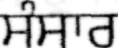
ਸੰਸਾਰ
